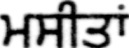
ਮਸੀਤਾਂ
